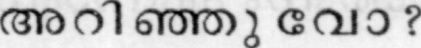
അറിഞ്ഞുവോ?
